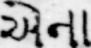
એના
